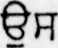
ਉਸ
